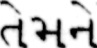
તેમને
